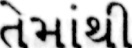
તેમાંથી
